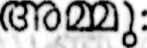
അമ്മു:
